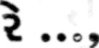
રે.....,
